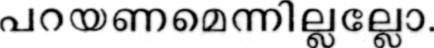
പറയണമെന്നില്ലല്ലോ.
